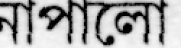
নাপালো
